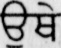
ਉਥੇ
